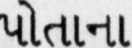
પોતાના
